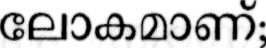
ലോകമാണ്;
